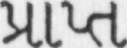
પ્રાપ્ત
